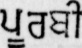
ਪੂਰਬੀ
